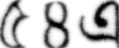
৫৪এ
